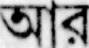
আর
